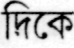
দিকে
